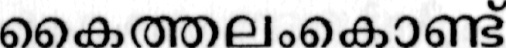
കൈത്തലംകൊണ്ട്
